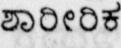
ಶಾರೀರಿಕ
